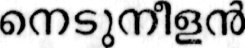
നെടുനീളന്‍
